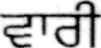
ਵਾਰੀ
